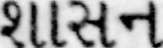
શાસન
